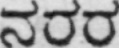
ನರರ
